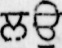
ਲਉ
